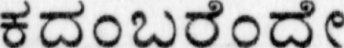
ಕದಂಬರೆಂದೇ
